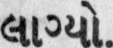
લાગ્યો.
